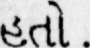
હતો.
